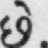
છે.
